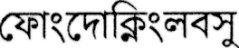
ফোংদোক্নিংলবসু
